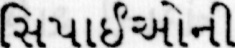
સિપાઈઓની
